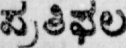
ಪ್ರತಿಫಲ
